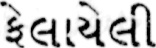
ફેલાયેલી
